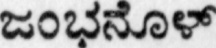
ಜಂಭನೊಳ್
